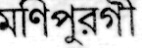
মণিপুরগী
